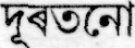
দূৰতনো
